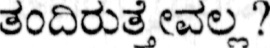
ತಂದಿರುತ್ತೇವಲ್ಲ?
